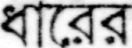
ধারের
